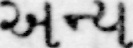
અન્ય
